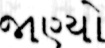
જાણ્યો
